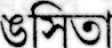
ঙসিতা
